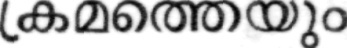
ക്രമത്തെയും
